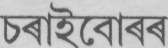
চৰাইবোৰৰ
